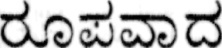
ರೂಪವಾದ
